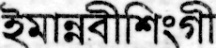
ইমান্নবীশিংগী
